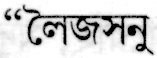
“লৈজসনু
